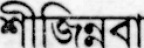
শীজিন্নবা
